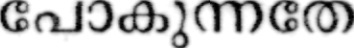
പോകുന്നതേ
